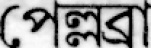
পেল্লব্রা
